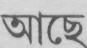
আছে
